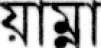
য়াম্না
